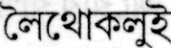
লৈথোকলুই
